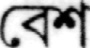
বেশ
